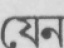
যেন
